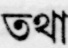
তথা
